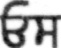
ਓਸ
